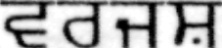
ਵਰਜਸ਼
